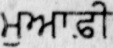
ਮੁਆਫ਼ੀ
